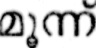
മൂന്ന്
